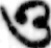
ও
